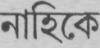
নাহিকে
